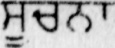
ਸੂਚਨਾ
